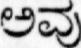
ಅವು
